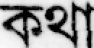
কথা
